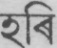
হৰি
